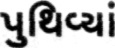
પુથિવ્યાં
